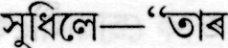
সুধিলে-"তাৰ
